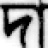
দা
